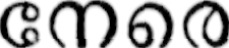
നേരെ
